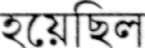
হয়েছিল
